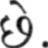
છે.
